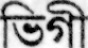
ভিগী
